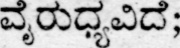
ವೈರುಧ್ಯವಿದೆ;
